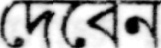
দেবেন
